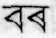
বৰ
